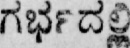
ಗರ್ಭದಲ್ಲಿ
